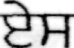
ਏਸ
